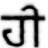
ਹੀ
